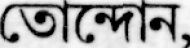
তোন্দোন,
